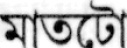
মাতটো
